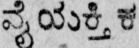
ವೈಯಕ್ತಿಕ
